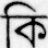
কি
